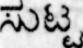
ಸುಟ್ಟ
